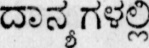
ದಾನ್ಯಗಳಲ್ಲಿ
